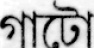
গাটো
